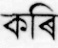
কৰি
